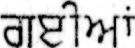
ਗਈਆਂ
